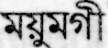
ময়ুমগী
